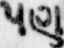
પણ
